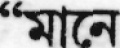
"মানে
